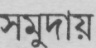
সমুদায়
